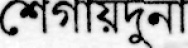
শেগায়দুনা
